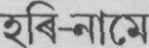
হৰি-নামে
